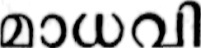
മാധവി
